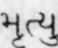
મૃત્યુ
